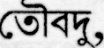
তৌবদু,
